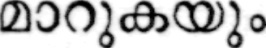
മാറുകയും
